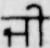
ਜੀ
